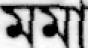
মমা
